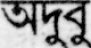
অদুবু
